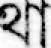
থা
